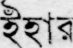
ইঁহার
